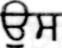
ਉਸ
